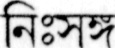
নিঃসঙ্গ
